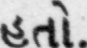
હતો.
